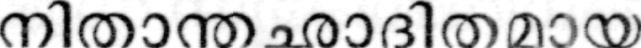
നിതാന്തഛാദിതമായ
